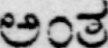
ಅಂತ
